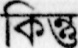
কিন্তু
